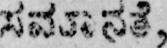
ಸಮಾನತೆ,
